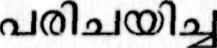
പരിചയിച്ച
